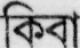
কিবা
